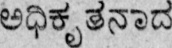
ಅಧಿಕೃತನಾದ
